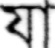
যা
